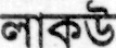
লকউ
